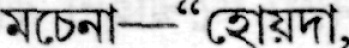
মচেনা-“হোয়দা,
